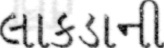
લાકડાની
